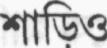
শাড়িও
